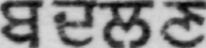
ਬਦਲਣ
